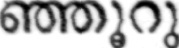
ഞ്ഞൂറു
